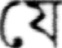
যে
